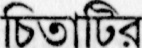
চিতাটির
